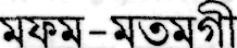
মফম-মতমগী
